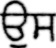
ਉਸ
